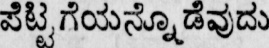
ಪೆಟ್ಟಿಗೆಯನ್ನೊಡೆವುದು
